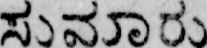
ಸುಮಾರು
